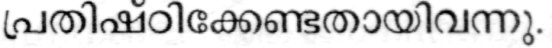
പ്രതിഷ്ഠിക്കേണ്ടതായിവന്നു.
